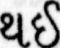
થઈ
